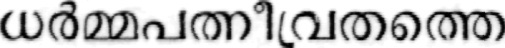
ധര്‍മ്മപത്നീവ്രതത്തെ
